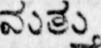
ಮತ್ತು
